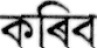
কৰিব
